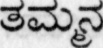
ತಮ್ಮನ
